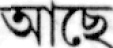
আছে
